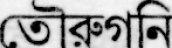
তৌরুগনি
